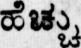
ಹೆಚ್ಚು
